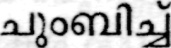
ചുംബിച്ച്
